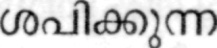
ശപിക്കുന്ന
